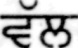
ਵੱਲ
